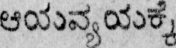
ಆಯವ್ಯಯಕ್ಕೆ
